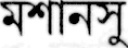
মশানসু
